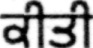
ਕੀਤੀ
